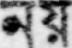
নয়
